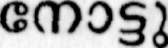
നോട്ടു
